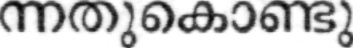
ന്നതുകൊണ്ടു
